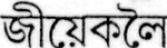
জীয়েকলৈ
